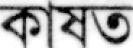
কাষত
